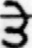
ਤੇ
